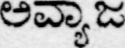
ಅವ್ಯಾಜ
